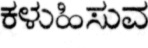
ಕಳುಹಿಸುವ
